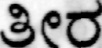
ತೀರ
